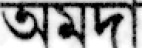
অমদা
